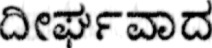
ದೀರ್ಘವಾದ
